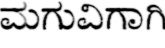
ಮಗುವಿಗಾಗಿ
